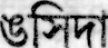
ঙসিদা
